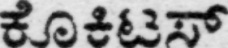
ಕೊಕಿಟಸ್
